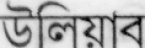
উলিয়াব
